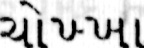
ચોખ્ખા
